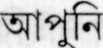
আপুনি
